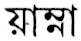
য়াম্না
